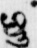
છું
